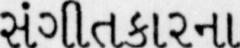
સંગીતકારના
